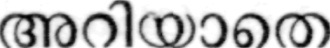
അറിയാതെ
